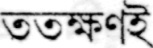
ততক্ষণই
